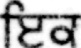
ਇਕ
